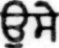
ਉਸੇ
